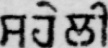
ਸਹੇਲੀ
